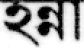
হন্না
